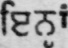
ਇਨ੍ਹਾਂ
